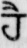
ਹੈ
